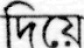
দিয়ে
